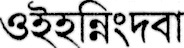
ওইহন্নিংদবা
